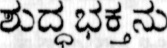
ಶುದ್ಧಭಕ್ತನು
